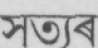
সত্যৰ
